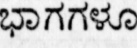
ಭಾಗಗಳೂ
